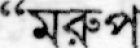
“মরুপ
